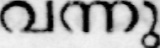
വന്നു
